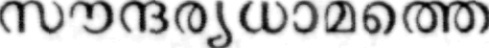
സൗന്ദര്യധാമത്തെ
